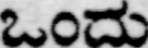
ಒಂದು
